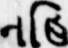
નહિ
